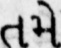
તમે
